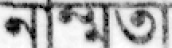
নাম্মতা
